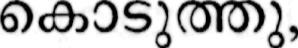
കൊടുത്തു,
